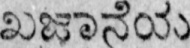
ಖಜಾನೆಯ
